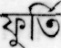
ফুর্তি
